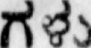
ಗಳು
